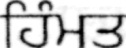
ਹਿੰਮਤ
